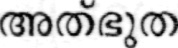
അത്ഭുത
